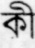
কী
